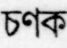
চণক
